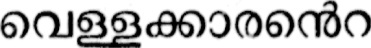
വെള്ളക്കാരന്റെ
